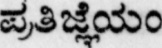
ಪ್ರತಿಜ್ಞೆಯಂ
